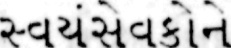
સ્વયંસેવકોને
